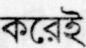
করেই
